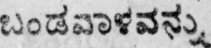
ಬಂಡವಾಳವನ್ನು
